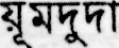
য়ূমদুদা
